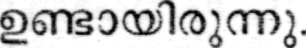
ഉണ്ടായിരുന്നു.
